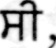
ਸੀ,
